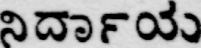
ನಿರ್ದಾಯ
